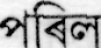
পৰিল
